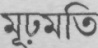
মূঢ়মতি
